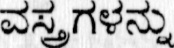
ವಸ್ತ್ರಗಳನ್ನು
